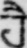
ਹੈ
